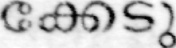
ക്കേടു
